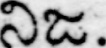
ನಿಜ.
